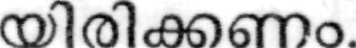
യിരിക്കണം.
